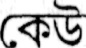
কেউ
